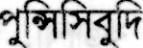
পুন্সিসিবুদি
